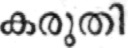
കരുതി
